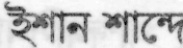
ইশান শান্দে
